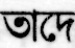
তাদে
